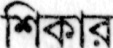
শিকার
